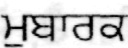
ਮੁਬਾਰਕ
